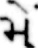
મેં
